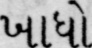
ખાધો
